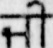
ਜੀ
